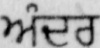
ਅੰਦਰ
